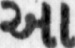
આ
